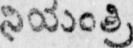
ನಿಯಂತ್ರಿ
